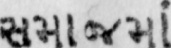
સમાજમાં
